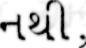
નથી,
